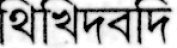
থিখিদবদি
